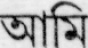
আমি
